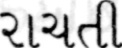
રાચતી
